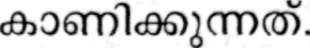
കാണിക്കുന്നത്.
